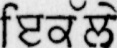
ਇਕੱਲੇ
